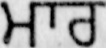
ਮਾਰ
